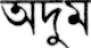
অদুম
